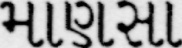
માણસા
